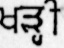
ਖੜ੍ਹੀ
